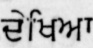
ਦੇਖਿਆ
